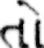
તો
